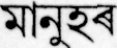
মানুহৰ
